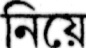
নিয়ে
